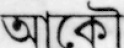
আকৌ
